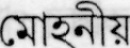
মোহনীয়
